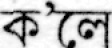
ক'লে
